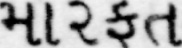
મારફત
